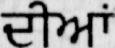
ਦੀਆਂ
